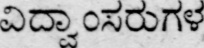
ವಿದ್ವಾಂಸರುಗಳ
